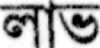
লাভ
